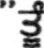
''ਤੂੰ
